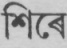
শিৰে
